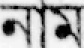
নাম
